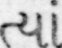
ત્યાં
